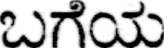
ಬಗೆಯ
